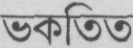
ভকতিত
